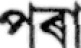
পৰা
